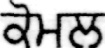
ਕੋਮਲ
